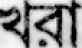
খরা
